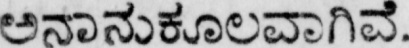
ಅನಾನುಕೂಲವಾಗಿವೆ.
